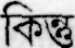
কিন্তু
